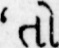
'તો
